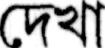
দেখা
